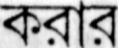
করার
